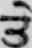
ਤੇ
